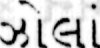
ઝોલાં
